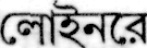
লোইনরে
